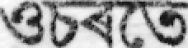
ওচৰতে
